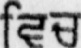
ਵਿਚ
